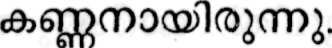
കണ്ണനായിരുന്നു.
